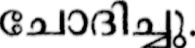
ചോദിച്ചു.
